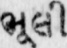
ભૂલી
